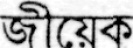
জীয়েক
